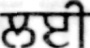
ਲਈ
